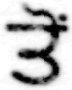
ਤੋਂ
